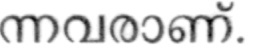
ന്നവരാണ്.
